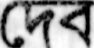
দেব
